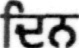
ਦਿਨ
